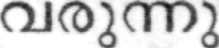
വരുന്നു
